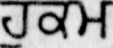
ਹੁਕਮ
